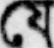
যে
